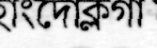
হাংদোক্লগা
